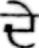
ਦੇ
